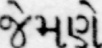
જેમણે
